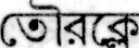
তৌরক্লে
